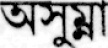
অসুম্না
